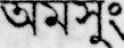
অমসুং
